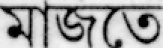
মাজতে
